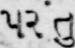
પરંતુ
